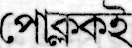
পোক্লকই
